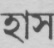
হাস
